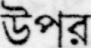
উপর
